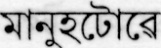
মানুহটোৱে
